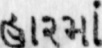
હારમાં
